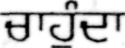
ਚਾਹੁੰਦਾ
